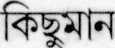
কিছুমান
